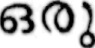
ഒരു
